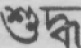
শুদ্ধ
